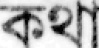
কথা
